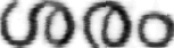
ശരം
